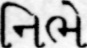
નિભે
